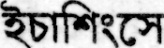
ইচাশিংসে
